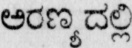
ಅರಣ್ಯದಲ್ಲಿ
